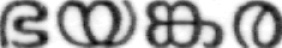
ഭയങ്കര
